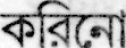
করিনো
